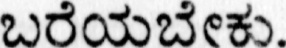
ಬರೆಯಬೇಕು.
